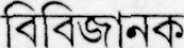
বিবিজানক
